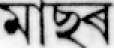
মাছৰ
